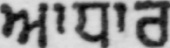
ਆਧਾਰ
